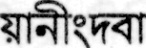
য়ানীংদবা
